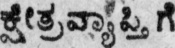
ಕ್ಷೇತ್ರವ್ಯಾಪ್ತಿಗೆ
